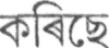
কৰিছে
